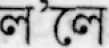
ল'লে
